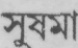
সুষমা
